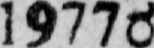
1977ರ
